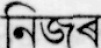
নিজৰ
